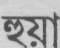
হুয়া
